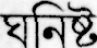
ঘনিষ্ট
